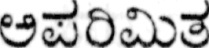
ಅಪರಿಮಿತ
